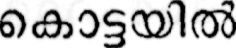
കൊട്ടയില്‍
